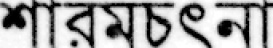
শারমচৎনা
